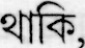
থাকি,
